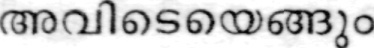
അവിടെയെങ്ങും
